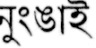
নুংঙাই
